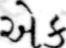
એક
